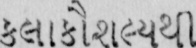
કલાકૌશલ્યથી
